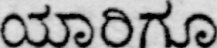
ಯಾರಿಗೂ
